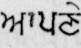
ਆਪਣੇ
